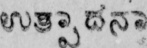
ಉತ್ಪಾದನಾ
